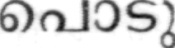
പൊടു
